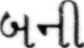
બની
